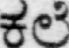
ಕಲೆ
